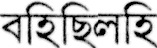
বহিছিলহি
